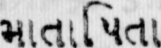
માતાપિતા
